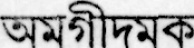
অমগীদমক
